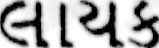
લાયક
